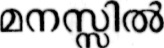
മനസ്സില്‍
